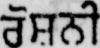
ਰੋਸ਼ਨੀ
